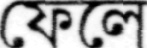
ফেলে
